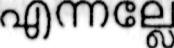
എന്നല്ലേ
